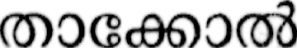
താക്കോല്‍
